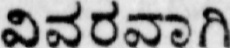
ವಿವರವಾಗಿ
